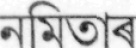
নমিতাৰ
